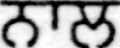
ਨਾਲ
